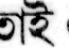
তাই
